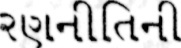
રણનીતિની
